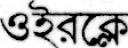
ওইরক্লে
